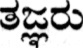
ತಜ್ಞರು
